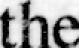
the
